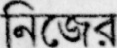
নিজের
